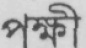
পক্ষী
